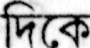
দিকে
